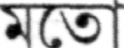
মতো
